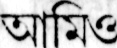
আমিও
